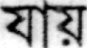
যায়
